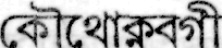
কৌথোক্নবগী
